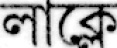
লাক্লে
